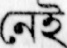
নেই
